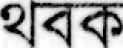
থবক
